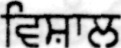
ਵਿਸ਼ਾਲ
